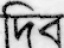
দিব
